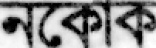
নকোক
